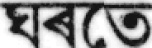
ঘৰতে
